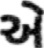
એ
